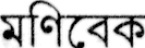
মণিবেক
